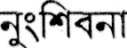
নুংশিবনা
